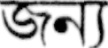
জন্য
